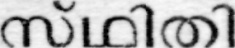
സ്ഥിതി
